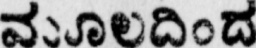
ಮೂಲದಿಂದ
